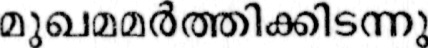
മുഖമമര്‍ത്തിക്കിടന്നു
